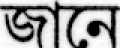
জানে
